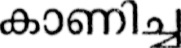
കാണിച്ച
